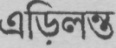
এড়িলন্ত
